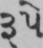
રૂપે
